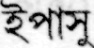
ইপাসু
